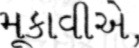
મૂકાવીએ,
